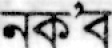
নক'ব
